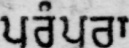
ਪਰੰਪਰਾ
